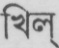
খিল্‌
